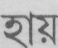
হায়
